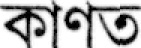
কাণত
